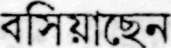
বসিয়াছেন
